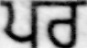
ਪਰ
